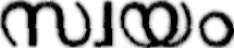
സ്വയം
